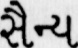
સૈન્ય
